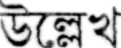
উল্লেখ
